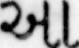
આ
